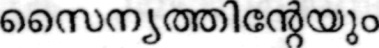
സൈന്യത്തിന്റേയും
